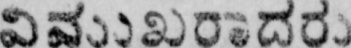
ವಿಮುಖರಾದರು
